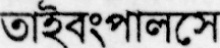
তাইবংপালসে
